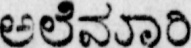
ಅಲೆಮಾರಿ
